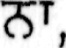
ਨਾ,
